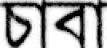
চাবা
